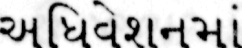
અધિવેશનમાં
